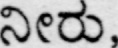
ನೀರು,
